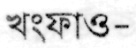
খংফাও-
